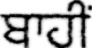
ਬਾਹੀਂ
